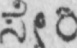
ಸೇರಿ
